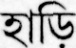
হাড়ি
